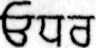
ਓਧਰ
